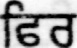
ਫਿਰ
